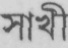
সাখী
